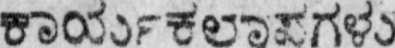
ಕಾರ್ಯಕಲಾಪಗಳು
